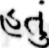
હતું
